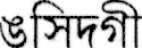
ঙসিদগী
